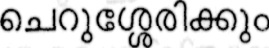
ചെറുശ്ശേരിക്കും
